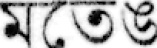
মতেঙ
